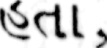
હતા,
